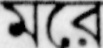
মরে
